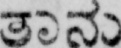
ತಾನು
